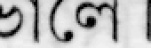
ভালে
